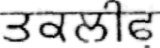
ਤਕਲੀਫ਼
